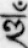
হুঁ
